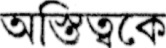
অস্তিত্বকে
